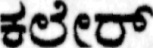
ಕಲೇರ್
